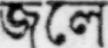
জলে
